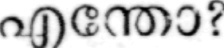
എന്തോ?
